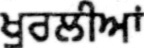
ਖੁਰਲੀਆਂ
